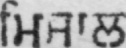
ਮਿਸਾਲ
